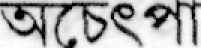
অচেৎপা
